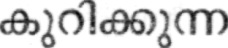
കുറിക്കുന്ന
